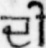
ਦੀ
